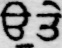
ਉਤੇ
